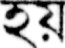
হয়
